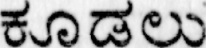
ಕೂಡಲು
